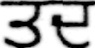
ਤਦ
